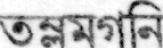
তম্লমগনি
